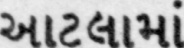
આટલામાં
